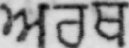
ਅਰਥ
